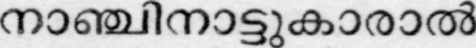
നാഞ്ചിനാട്ടുകാരാല്‍
